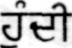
ਹੁੰਦੀ
